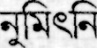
নুমিৎনি
